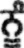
ਨੂੰ
